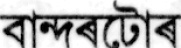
বান্দৰটোৰ
